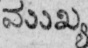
ಮುಖ್ಯ
